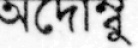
অদোম্বু
